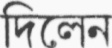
দিলেন
